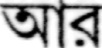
আর
